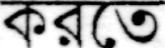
করতে
